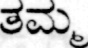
ತಮ್ಮ
